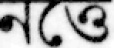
নত্তে
